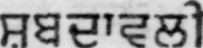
ਸ਼ਬਦਾਵਲੀ
